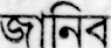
জানিব
